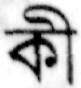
কী
